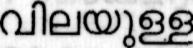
വിലയുള്ള
